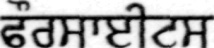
ਫੌਰਸਾਈਟਸ
